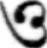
ও
